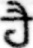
ਹੈ
